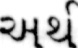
અર્થ
